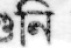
শুনি
